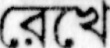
রেখে
